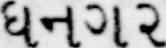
ધનગર
